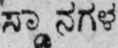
ಸ್ಥಾನಗಳ
